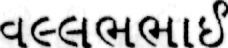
વલ્લભભાઈ
